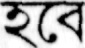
হবে
